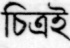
চিত্রই
